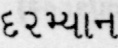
દરમ્યાન
